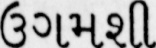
ઉગમશી
